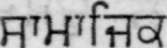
ਸਾਮਾਜਿਕ
